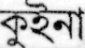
কুইনা
